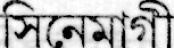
সিনেমাগী
